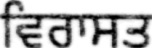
ਵਿਰਾਸਤ
